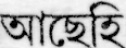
আছেহি
